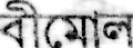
বীমোল
